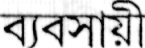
ব্যবসায়ী
